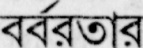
বর্বরতার
